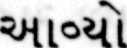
આવ્યો
